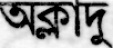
অক্লাদু
